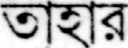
তাহার
